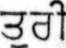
ਤੁਰੀ
